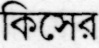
কিসের
